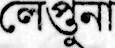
লেপ্তুনা
